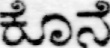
ಕೊನೆ
